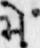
મેં
